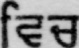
ਵਿਚ
